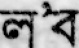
ল'ব
